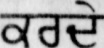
ਕਰਦੇ
